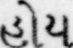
હોય
